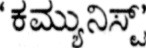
'ಕಮ್ಯುನಿಸ್ಟ್'
